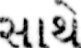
સાથે
